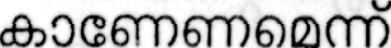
കാണേണമെന്ന്
